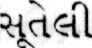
સૂતેલી
